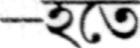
-হতে
